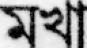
মখা
